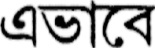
এভাবে
